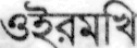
ওইরমখি
